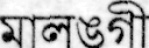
মালঙগী
